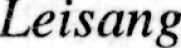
Leisang
